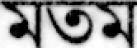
মতম
